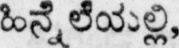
ಹಿನ್ನೆಲೆಯಲ್ಲಿ,
